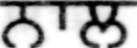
ਨਾਲ
